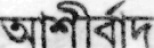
আশীর্বাদ
